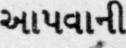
આપવાની
